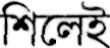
শিলেই
